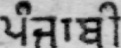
ਪੰਜਾਬੀ
